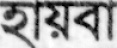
হায়বা
